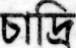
চাদ্রি
